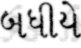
બધીયે
